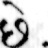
છે.
